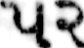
પર
